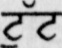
ਟੁੱਟ
